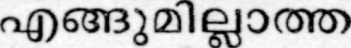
എങ്ങുമില്ലാത്ത
